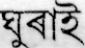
ঘুৰাই
